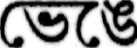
ভেঙে
